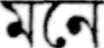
মনে
